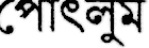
পোৎলুম
